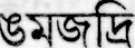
ঙমজদ্রি
